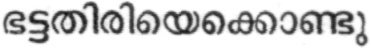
ഭട്ടതിരിയെക്കൊണ്ടു
